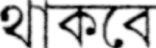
থাকবে
